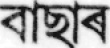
বাছাৰ
